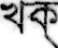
খক্
